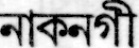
নাকনগী
